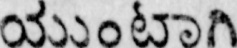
ಯುಂಟಾಗಿ
